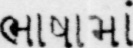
ભાષામાં
